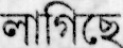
লাগিছে
